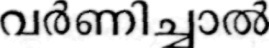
വര്‍ണിച്ചാല്‍
